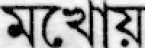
মখোয়
